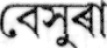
বেসুৰা
